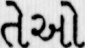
તેઓ
